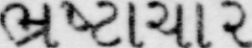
ભ્રષ્ટાચાર
